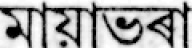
মায়াভৰা
